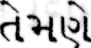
તેમણે
